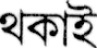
থকাই
